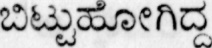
ಬಿಟ್ಟುಹೋಗಿದ್ದ
